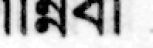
শান্নবা
